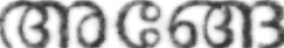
അങ്ങേ
